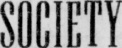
SOCIETY
